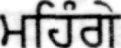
ਮਹਿੰਗੇ
